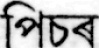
পিচৰ
